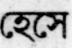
হেসে
